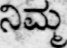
ನಿಮ್ಮ
